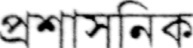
প্রশাসনিক
